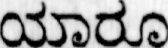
ಯಾರೂ
